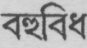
বহুবিধ
